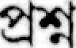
প্রশ্ন
